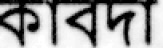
কাবদা
